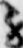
કે
